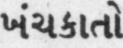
ખંચકાતો
